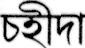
চহীদা
